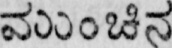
ಮುಂಚಿನ
